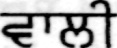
ਵਾਲੀ
